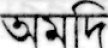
অমদি
